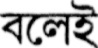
বলেই
